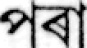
পৰা
